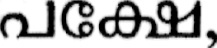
പക്ഷേ,
